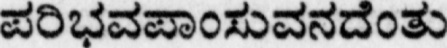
ಪರಿಭವಪಾಂಸುವನದೆಂತು
